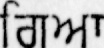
ਗਿਆ
